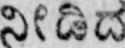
ನೀಡಿದ
